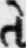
તે
